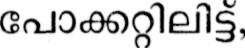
പോക്കറ്റിലിട്ട്,
